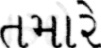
તમારે
